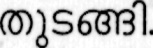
തുടങ്ങി.
